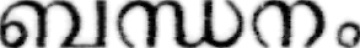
ബന്ധനം
